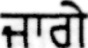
ਜਾਗੇ
